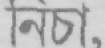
নিচা,
